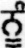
ਨੂੰ
